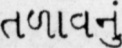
તળાવનું
